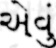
એવું
